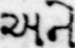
અને
